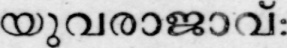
യുവരാജാവ്:
